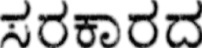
ಸರಕಾರದ
